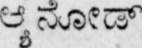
ಆನೋಡ್
